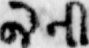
જેની
